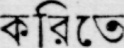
করিতে
